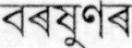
বৰষুণৰ
